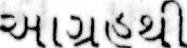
આગ્રહથી
